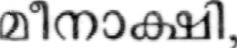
മീനാക്ഷി,
